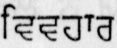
ਵਿਵਹਾਰ
